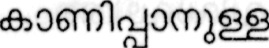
കാണിപ്പാനുള്ള
